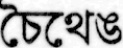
চৈথেঙ
